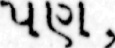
પણ,
